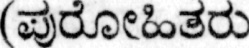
(ಪುರೋಹಿತರು
